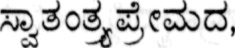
ಸ್ವಾತಂತ್ರ್ಯಪ್ರೇಮದ,
